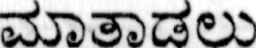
ಮಾತಾಡಲು
